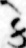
કે
